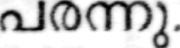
പരന്നു.
